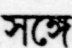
সঙ্গে
